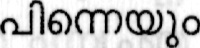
പിന്നെയും
